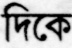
দিকে
